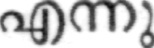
എന്നു
